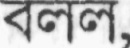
বলল,
